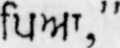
ਪਿਆ,''
